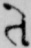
તે
